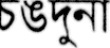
চঙদুনা
